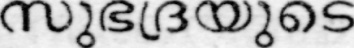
സുഭദ്രയുടെ
